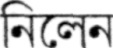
নিলেন
